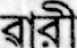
ৱারী
